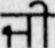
ਜੀ
